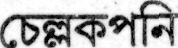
চেল্লকপনি
